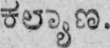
ಕಲ್ಯಾಣ.
